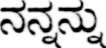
ನನ್ನನ್ನು
